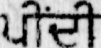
ਪੀਂਦੀ
